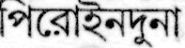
পিরোইনদুনা
